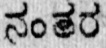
ನಂತರ
